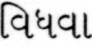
વિધવા
